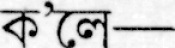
ক'লে-
